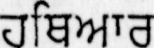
ਹਥਿਆਰ
